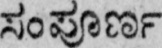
ಸಂಪೂರ್ಣ
